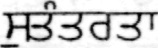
ਸੁਤੰਤਰਤਾ
